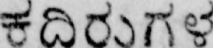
ಕದಿರುಗಳ
